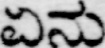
ಏನು
